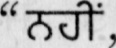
''ਨਹੀਂ,
